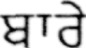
ਬਾਰੇ
